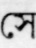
সে
